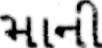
માની
